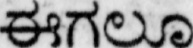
ಈಗಲೂ
